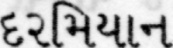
દરમિયાન
